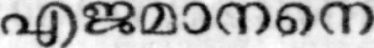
എജമാനനെ
